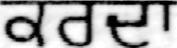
ਕਰਦਾ
